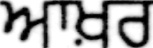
ਆਖ਼ਰ
